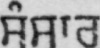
ਸੰਸਾਰ
